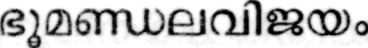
ഭൂമണ്ഡലവിജയം
